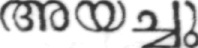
അയച്ചു
